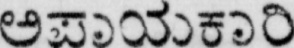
ಅಪಾಯಕಾರಿ
